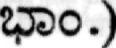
ಭಾಂ.)
